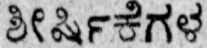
ಶೀರ್ಷಿಕೆಗಳ
